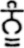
ਨੂੰ
